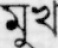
মুখ
